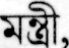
মন্ত্রী,
